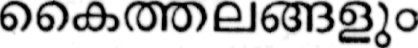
കൈത്തലങ്ങളും
